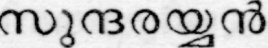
സുന്ദരയ്യന്‍
